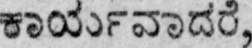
ಕಾರ್ಯವಾದರೆ,
